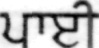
ਪਾਈ
